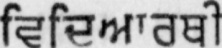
ਵਿਦਿਆਰਥੀ
